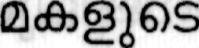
മകളുടെ
